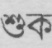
শুক
